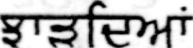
ਝਾੜਦਿਆਂ
